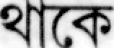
থাকে
